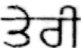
ਤੇਰੀ
